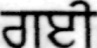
ਗਈ
